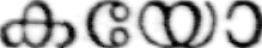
കയോ
